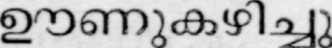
ഊണുകഴിച്ചു
